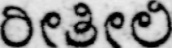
ರೀತೀಲಿ
